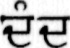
ਦੰਦ
